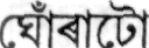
ঘোঁৰাটো
